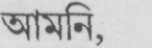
আমনি,
